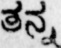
ತನ್ನ
